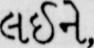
લઈને,
